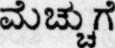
ಮೆಚ್ಚುಗೆ
